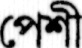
পেশী
